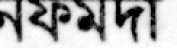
নফমদা
